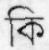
কি
